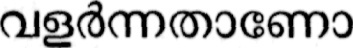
വളര്‍ന്നതാണോ
